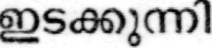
ഇടക്കുന്നി
